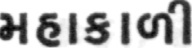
મહાકાળી
